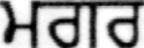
ਮਗਰ
